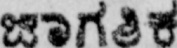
ಜಾಗತಿಕ
